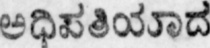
ಅಧಿಪತಿಯಾದ
